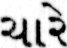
ચારે
